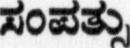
ಸಂಪತ್ಸು
